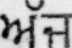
ਅੱਜ
